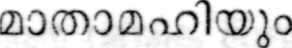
മാതാമഹിയും
